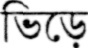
ভিড়ে
